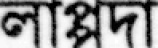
লাপ্পদা
